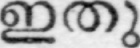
ഇതു
